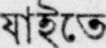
যাইতে
